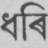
ধৰি
